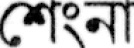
শেংনা
